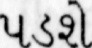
પડશે
